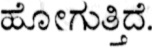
ಹೋಗುತ್ತಿದೆ.
